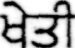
ਖੇਤੀ
